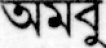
অমবু
